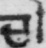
ਦੀ
